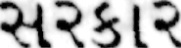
સરકાર
